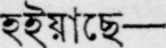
হইয়াছে—
